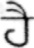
ਹੈ
